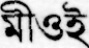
মীওই
